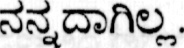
ನನ್ನದಾಗಿಲ್ಲ.
